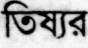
তিষ্যর
